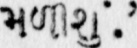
મળીશું.'
